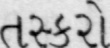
તસ્કરો
